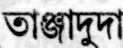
তাঞ্জাদুদা
